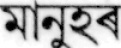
মানুহৰ
